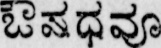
ಔಷಧವೂ
